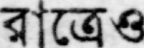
রাত্রেও
